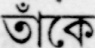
তাঁকে
